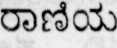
ರಾಣಿಯ
